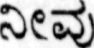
ನೀವು
